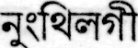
নুংথিলগী
